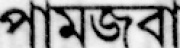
পামজবা
